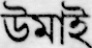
উমাই
